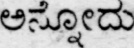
ಅನ್ನೋದು
